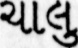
ચાલુ
